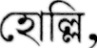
হোল্লি,
